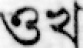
ওখ
